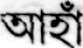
আহাঁ
